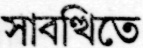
সাবত্থিতে
